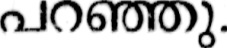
പറഞ്ഞു.
